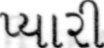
પ્યારી
